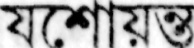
যশোয়ন্ত
